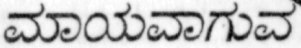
ಮಾಯವಾಗುವ
